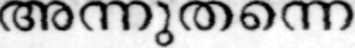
അന്നുതന്നെ
